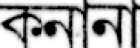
কনানা
